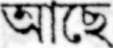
আছে
